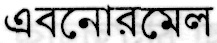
এবনোরমেল
